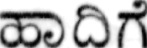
ಹಾದಿಗೆ
